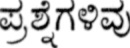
ಪ್ರಶ್ನೆಗಳಿವು
